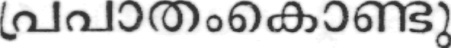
പ്രപാതംകൊണ്ടു
